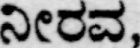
ನೀರವ,
